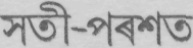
সতী-পৰশত
